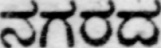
ನಗರದ
